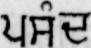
ਪਸੰਦ
